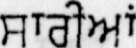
ਸਾਰੀਆਂ
